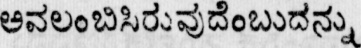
ಅವಲಂಬಿಸಿರುವುದೆಂಬುದನ್ನು
